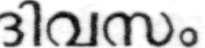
ദിവസം
